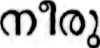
നീരു
